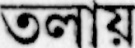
তলায়
